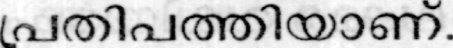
പ്രതിപത്തിയാണ്.
